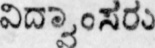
ವಿದ್ವಾಂಸರು
